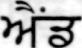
ਐਂਡ
